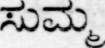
ಸುಮ್ಮ
